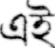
এই
